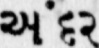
અંદર
